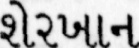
શેરખાન
